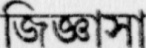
জিজ্ঞাসা
